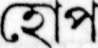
হোপ
